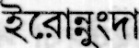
ইরোন্নুংদা
